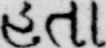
હતા
